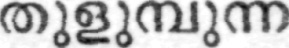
തുളുമ്പുന്ന
